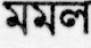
মমল
